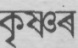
কৃষ্ণৰ
